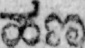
ಹಣ
